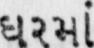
ઘરમાં
